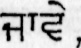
ਜਾਵੇ,
